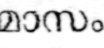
മാസം
